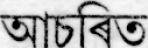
আচৰিত
